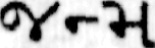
જન્મ
